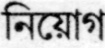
নিয়োগ
